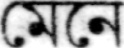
মেনে
